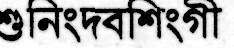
শুনিংদবশিংগী
